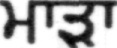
ਮਾੜਾ
